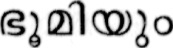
ഭൂമിയും
